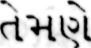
તેમણે
